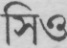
সিও
